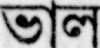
ভাল
